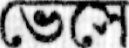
ভেসে
